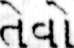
તેવો
